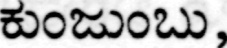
ಕುಂಜುಂಬು,
